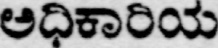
ಅಧಿಕಾರಿಯ
